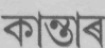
কান্তাৰ
